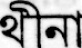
থীনা
